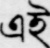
এই
